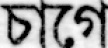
চাগে
